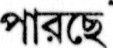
পারছে
